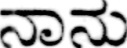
ನಾನು
